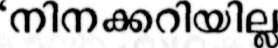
‘നിനക്കറിയില്ല
